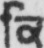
ਕਿ
